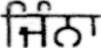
ਜਿੰਨਾ
